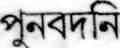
পুনবদনি
